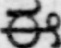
ಈ
